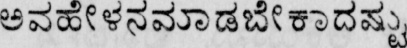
ಅವಹೇಳನಮಾಡಬೇಕಾದಷ್ಟು
